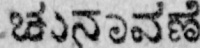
ಚುನಾವಣೆ
